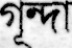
গূন্দা
